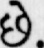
છે.
